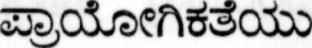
ಪ್ರಾಯೋಗಿಕತೆಯು
